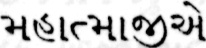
મહાત્માજીએ
